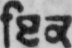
ਇਕ
